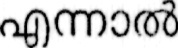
എന്നാല്‍
